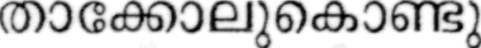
താക്കോലുകൊണ്ടു
